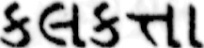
કલકત્તા
